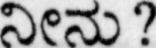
ನೀನು?
